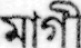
মাগী
